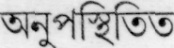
অনুপস্থিতিত
